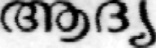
ആദ്യ
